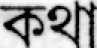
কথা
